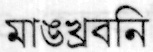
মাঙখ্রবনি
